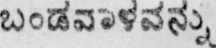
ಬಂಡವಾಳವನ್ನು
